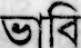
ভাবি
